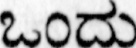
ಒಂದು
